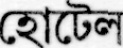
হোটেল
